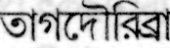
তাগদৌরিব্রা
